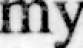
my
